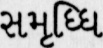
સમૃધ્ધિ
